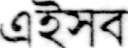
এইসব
